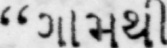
"ગામથી
